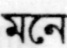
মনে
